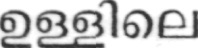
ഉള്ളിലെ
